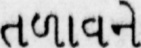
તળાવને
